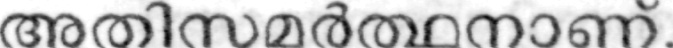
അതിസമര്‍ത്ഥനാണ്.
